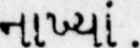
નાખ્યાં.
